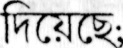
দিয়েছে;
